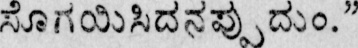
ಸೊಗಯಿಸಿದನಪ್ಪುದುಂ.”
